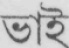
ভাই
